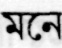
মনে
